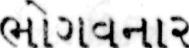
ભોગવનાર
